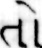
તો
